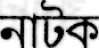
নাটক
